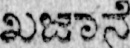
ಖಜಾನೆ
